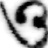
ও
